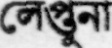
লেপ্তুনা
